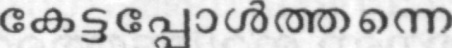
കേട്ടപ്പോള്‍ത്തന്നെ
